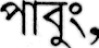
পাবুং,
